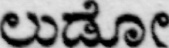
ಲುಡೋ
